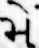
મેં
